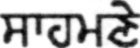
ਸਾਹਮਣੇ
